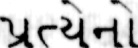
પ્રત્યેનો
